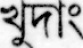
খুদাং
